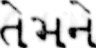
તેમને
